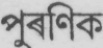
পুৰণিক
